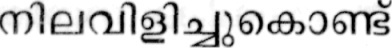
നിലവിളിച്ചുകൊണ്ട്
